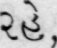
રહે,
